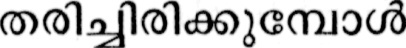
തരിച്ചിരിക്കുമ്പോള്‍
